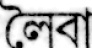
লৈবা
